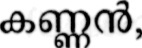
കണ്ണന്‍,
